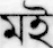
মই
